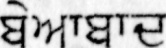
ਬੇਆਬਾਦ
